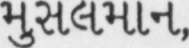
મુસલમાન,
